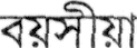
বয়সীয়া
